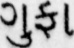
ગુફા
